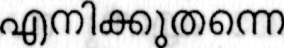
എനിക്കുതന്നെ
